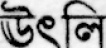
ঊৎলি
